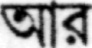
আর
